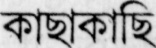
কাছাকাছি
